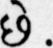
છે.
